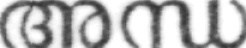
അന്ധ
